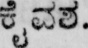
ಕೈವಶ.
